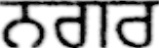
ਨਗਰ
